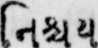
નિશ્ચય
